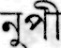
নুপী
